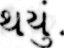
થયું.
